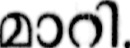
മാറി.
